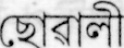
ছোৱালী
